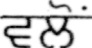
ਵਲੋਂ
